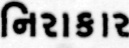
નિરાકાર
